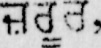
ਜ਼ਰੂਰ,
